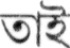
তাই
